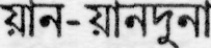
য়ান-য়ানদুনা
